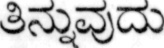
ತಿನ್ನುವುದು
